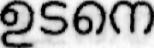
ഉടനെ
